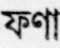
ফণা
